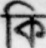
কি
